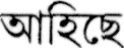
আহিছে
